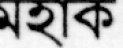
মহাক
